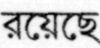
রয়েছে
